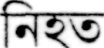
নিহত
